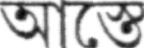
আস্তে
